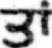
ਤਾਂ
